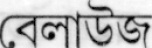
বেলাউজ
